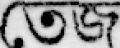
তেজ
